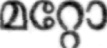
മറ്റോ
